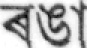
ৰঙা
